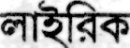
লাইরিক
